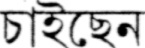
চাইছেন
